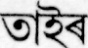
তাইৰ
